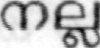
നല്ല
